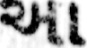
આ
